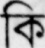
কি
